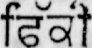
ਫਿੱਕੀ
